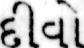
દીવો
